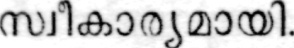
സ്വീകാര്യമായി.
